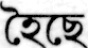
হৈছে
